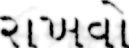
રાખવો
